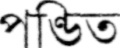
পণ্ডিত
